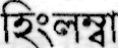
হিংলম্বা
